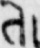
તો
